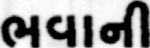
ભવાની
